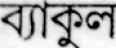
ব্যাকুল
